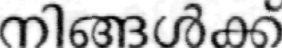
നിങ്ങള്‍ക്ക്
